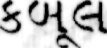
કબૂલ
